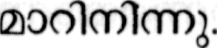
മാറിനിന്നു.
